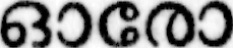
ഓരോ
